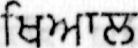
ਖਿਆਲ
